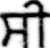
ਸੀ
